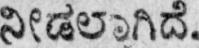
ನೀಡಲಾಗಿದೆ.
